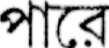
পারে
